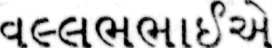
વલ્લભભાઈએ
